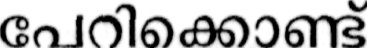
പേറിക്കൊണ്ട്
